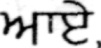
ਆਏ,
